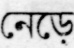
নেড়ে
